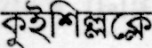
কুইশিল্লক্লে
